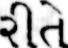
રીતે
